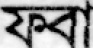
ফবা
